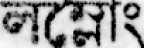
লম্লোং
